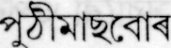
পুঠীমাছবোৰ
